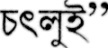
চৎলুই”
